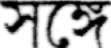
সঙ্গে
